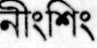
নীংশিং
